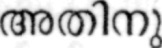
അതിനു
